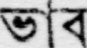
ভাব
